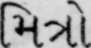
મિત્રો
